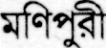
মণিপুরী
